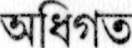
অধিগত
